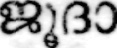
ജൂദാ
